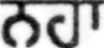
ਨਹਾ
